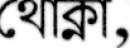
থোক্না,
